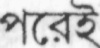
পরেই
